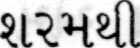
શરમથી
